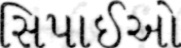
સિપાઈઓ
